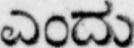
ಎಂದು
